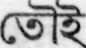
তৌই
